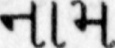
નામ
